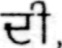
ਦੀ,
